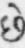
છે
